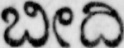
ಬೀದಿ
